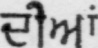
ਦੀਆਂ
